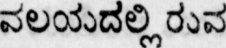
ವಲಯದಲ್ಲಿರುವ
